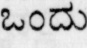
ಒಂದು
